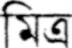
মিত্র
